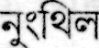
নুংথিল
